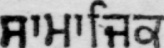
ਸਾਮਾਜਿਕ
